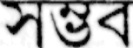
সম্ভব
